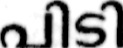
പിടി
